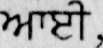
ਆਈ,
